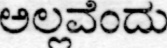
ಅಲ್ಲವೆಂದು
